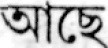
আছে
